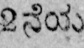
2ನೆಯ
